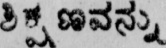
ಶಿಕ್ಷಣವನ್ನು
